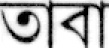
তাবা
